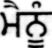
ਮੈਨੂੰ
